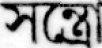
সন্ত্রো
